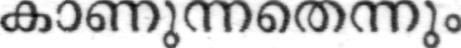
കാണുന്നതെന്നും
